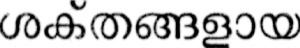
ശക്തങ്ങളായ
